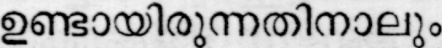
ഉണ്ടായിരുന്നതിനാലും
